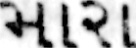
મારા
